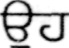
ਉਹ
